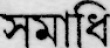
সমাধি
